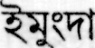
ইমুংদা
